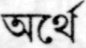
অর্থে
